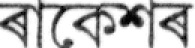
ৰাকেশৰ
